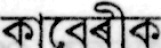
কাবেৰীক
